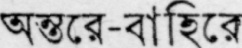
অন্তরে-বাহিরে
